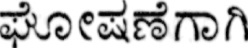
ಘೋಷಣೆಗಾಗಿ
